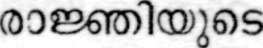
രാജ്ഞിയുടെ
